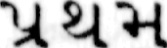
પ્રથમ
